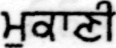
ਮੁਕਾਣੀ
